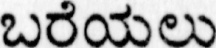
ಬರೆಯಲು
